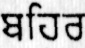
ਬਹਿਰ
